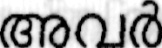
അവര്‍
